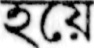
হয়ে
